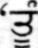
'ਤੂੰ
